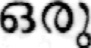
ഒരു
